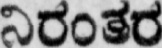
ನಿರಂತರ
